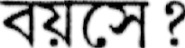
বয়সে?
